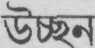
উচ্ছন
